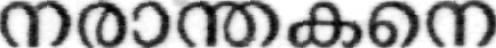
നരാന്തകനെ
